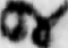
જ
